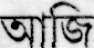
আজি
